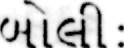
બોલીઃ
